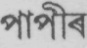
পাপীৰ
